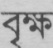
বৃক্ষ
